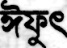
ঈফুৎ
